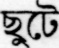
ছুটে
